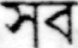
সব
